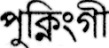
পুক্নিংগী
